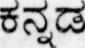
ಕನ್ನಡ
